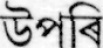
উপৰি
